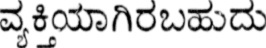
ವ್ಯಕ್ತಿಯಾಗಿರಬಹುದು
